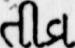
તીવ્ર
